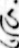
હું
